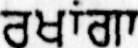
ਰਖਾਂਗਾ
